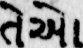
તેઓ
